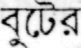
বুটের
